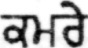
ਕਮਰੇ
